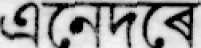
এনেদৰে
